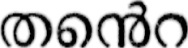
തന്റെ
